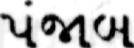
પંજાબ
